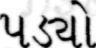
પડ્યો
